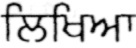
ਲਿਖਿਆ
